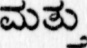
ಮತ್ತು
